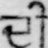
ਦੀ
